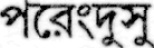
পরেংদুসু
